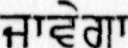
ਜਾਵੇਗਾ
